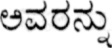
ಅವರನ್ನು
